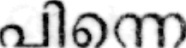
പിന്നെ
